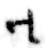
ન
